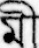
মী
